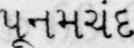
પૂનમચંદ
